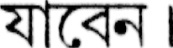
যাবেন।
